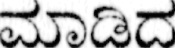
ಮಾಡಿದ
